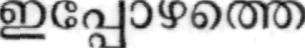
ഇപ്പോഴത്തെ
